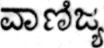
ವಾಣಿಜ್ಯ
